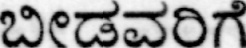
ಬೀಡವರಿಗೆ
